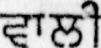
ਵਾਲੀ
